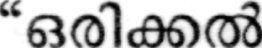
“ഒരിക്കല്‍
